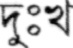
দুঃখ
